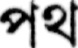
পথ
